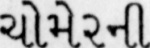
ચોમેરની
